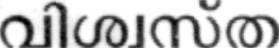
വിശ്വസ്ത
